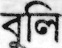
বুলি
